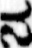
ನ
